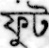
ফুট
